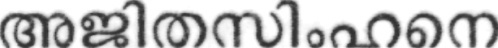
അജിതസിംഹനെ
